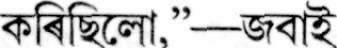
কৰিছিলো,"-জবাই
